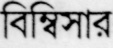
বিম্বিসার
